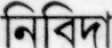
নিবিদা
